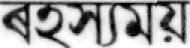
ৰহস্যময়
